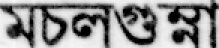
মচলগুম্না
